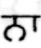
ਨਾ
